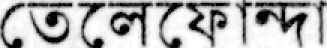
তেলেফোন্দা
